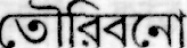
তৌরিবনো
